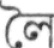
লৈ
